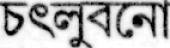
চৎলুবনো
